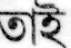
তাই
